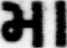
મા
